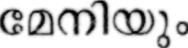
മേനിയും
